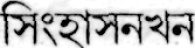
সিংহাসনখন
